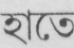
হাতে
